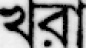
খরা
